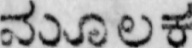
ಮೂಲಕ
